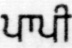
ਪਾਪੀ
